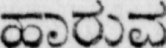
ಹಾರುವ
